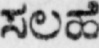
ಸಲಹೆ
